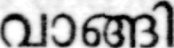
വാങ്ങി
